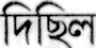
দিছিল
